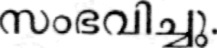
സംഭവിച്ചു.
